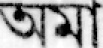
অমা
